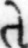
તે
